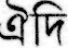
ঐদি
